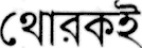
থোরকই
